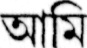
আমি
